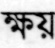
ক্ষয়
